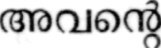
അവന്റെ
